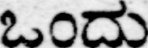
ಒಂದು
